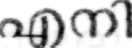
എനി
